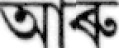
আৰু
